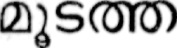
മൂടത്ത
